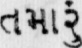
તમારું
